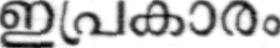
ഇപ്രകാരം
